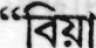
"বিয়া
